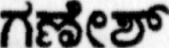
ಗಣೇಶ್
